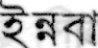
ইন্নবা
